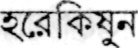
হরেকিষুন
